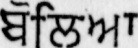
ਬੋਲਿਆ
